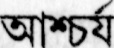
আশ্চর্য
